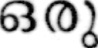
ഒരു
